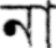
না
